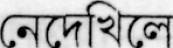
নেদেখিলে
